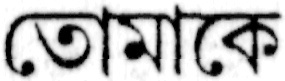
তোমাকে
